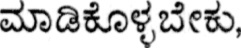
ಮಾಡಿಕೊಳ್ಳಬೇಕು,
